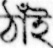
ঠাঁই
